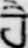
ਹੈ
